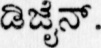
ಡಿಜೈನ್.
